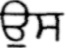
ਉਸ
